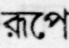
রূপে
